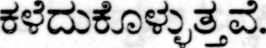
ಕಳೆದುಕೊಳ್ಳುತ್ತವೆ.
